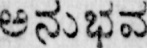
ಅನುಭವ
